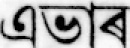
এভাৰ
